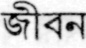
জীবন
